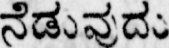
ನೆಡುವುದು
